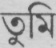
তুমি
